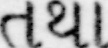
તથા
